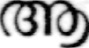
ആ
